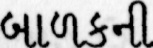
બાળકની
